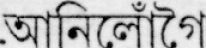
আনিলোঁগৈ
